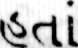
હતાં
